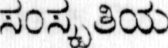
ಸಂಸ್ಕೃತಿಯ
